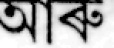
আৰু
